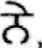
ਨੇ,
